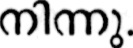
നിന്നു.
